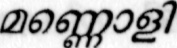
മണ്ണൊളി
